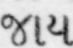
જાય
